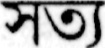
সত্য
